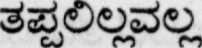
ತಪ್ಪಲಿಲ್ಲವಲ್ಲ
